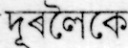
দূৰলৈকে
